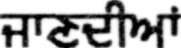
ਜਾਣਦੀਆਂ
